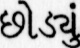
છોડ્યું
